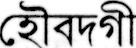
হৌবদগী
